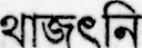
থাজৎনি
